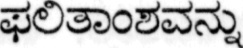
ಫಲಿತಾಂಶವನ್ನು
